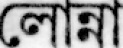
লোন্না
